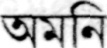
অমনি
